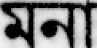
মনা
